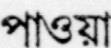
পাওয়া
